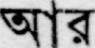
আর
